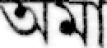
অমা
